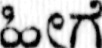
ಹೀಗೆ
